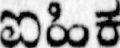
ಐಹಿಕ
